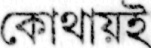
কোথায়ই
